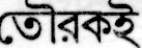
তৌরকই
